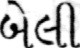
બેલી
